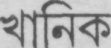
খানিক
